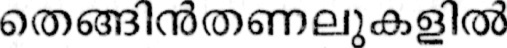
തെങ്ങിന്‍തണലുകളില്‍
